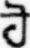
ਹੋ
